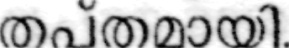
തപ്തമായി.
